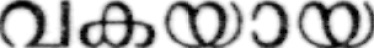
വകയായ
